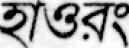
হাওরং
